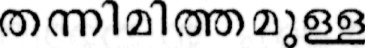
തന്നിമിത്തമുള്ള
